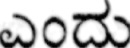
ಎಂದು
